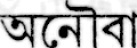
অনৌবা
